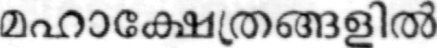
മഹാക്ഷേത്രങ്ങളില്‍
